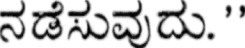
ನಡೆಸುವುದು."
